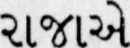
રાજાએ
